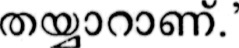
തയ്യാറാണ്.’
